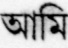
আমি
